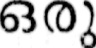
ഒരു
